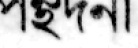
পন্থদনা
